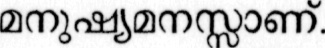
മനുഷ്യമനസ്സാണ്.
